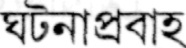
ঘটনাপ্রবাহ
